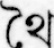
থৈ
